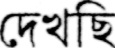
দেখছি
